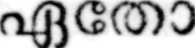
ഏതോ
